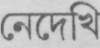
নেদেখি
